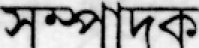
সম্পাদক
